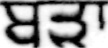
ਬੜਾ
